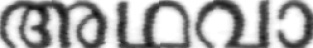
അഥവാ
